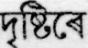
দৃষ্টিৰে
